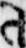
તે
